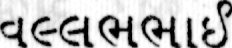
વલ્લભભાઈ
